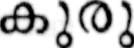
കുരു
